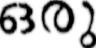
ഒരു
